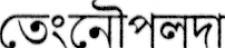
তেংনৌপলদা
